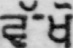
ਵੱਖੋ
